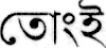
তোংই
